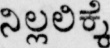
ನಿಲ್ಲಲಿಕ್ಕೆ
